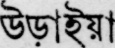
উড়াইয়া
